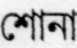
শোনা
